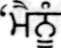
'ਮੈਨੂੰ
